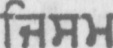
ਜਿਸਮ
